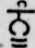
ਨੂੰ
